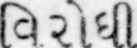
વિરોધી
